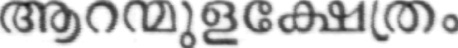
ആറന്മുളക്ഷേത്രം
